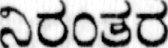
ನಿರಂತರ
